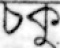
চকু
